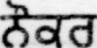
ਨੌਕਰ
